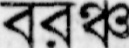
বরঞ্চ
